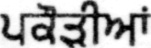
ਪਕੌੜੀਆਂ
